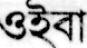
ওইবা
